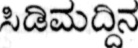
ಸಿಡಿಮದ್ದಿನ
